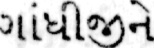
ગાંધીજીને
